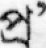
প্র'
